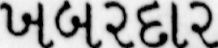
ખબરદાર
